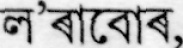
ল'ৰাবোৰ,
